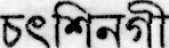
চৎশিনগী
